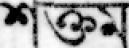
শক্তম
